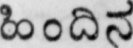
ಹಿಂದಿನ
